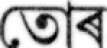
তোৰ
